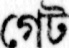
গেট
